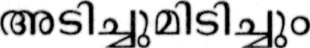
അടിച്ചുമിടിച്ചും
